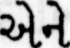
એને
